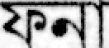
ফনা
